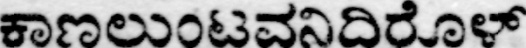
ಕಾಣಲುಂಟವನಿದಿರೊಳ್
